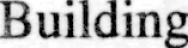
Building
